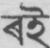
ৰই
